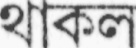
থাকল
